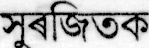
সুৰজিতক
